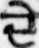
ਦੇ
